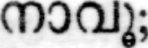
നാവൂ;
